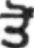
ਤੋਂ
